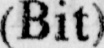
(Bit)
